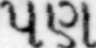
પણ
